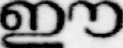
ഈ
